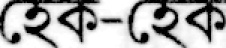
হেক-হেক
